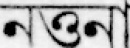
নত্তনা
